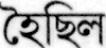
হৈছিল
